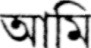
আমি
